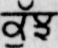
ਕੁੱਝ
